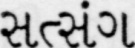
સત્સંગ
